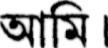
আমি।
